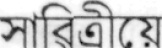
সাৱিত্রীয়ে
